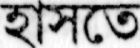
হাসতে
